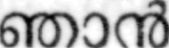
ഞാന്‍
